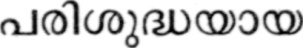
പരിശുദ്ധയായ
